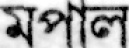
মপাল
